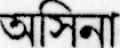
অসিনা
